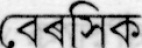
বেৰসিক
